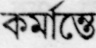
কর্মান্তে
